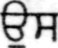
ਉਸ
